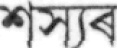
শস্যৰ
